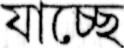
যাচ্ছে
